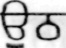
ਉਠ
